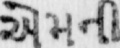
એમની
